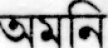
অমনি
